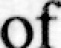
of
